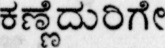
ಕಣ್ಣೆದುರಿಗೇ
